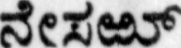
ನೇಸಱ್
